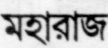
মহারাজ
